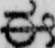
ಈ
